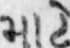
માટે
